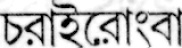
চরাইরোংবা
